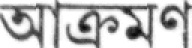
আক্রমণ
